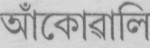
আঁকোৱালি
